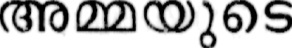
അമ്മയുടെ
